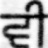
ਵੀ
